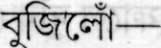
বুজিলোঁ-
